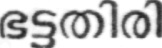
ഭട്ടതിരി
